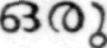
ഒരു
